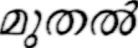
മുതല്‍
